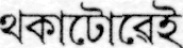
থকাটোৱেই
